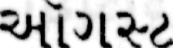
ઑગસ્ટ
